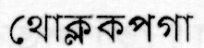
থোক্লকপগা
